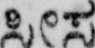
ಸೀಸ
